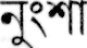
নুংশা
